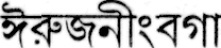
ঈরুজনীংবগা
